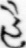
હૈ
